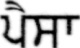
ਪੈਸਾ
